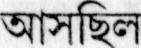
আসছিল
